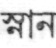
স্নান
